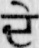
ਦੇ
